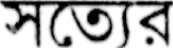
সত্যের
